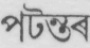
পটন্তৰ
